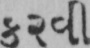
કરવી
